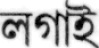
লগাই
